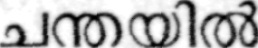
ചന്തയില്‍
